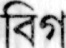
বিগ
